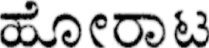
ಹೋರಾಟ
